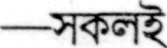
–সকলই
